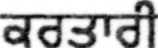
ਕਰਤਾਰੀ
